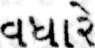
વધારે
